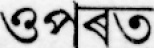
ওপৰত
